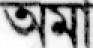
অমা
